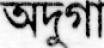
অদুগা
